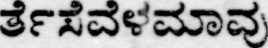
ತೆಸೆವೆಳಮಾವು
